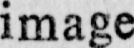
image
